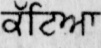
ਕੱਟਿਆ
